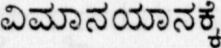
ವಿಮಾನಯಾನಕ್ಕೆ
